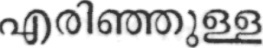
എരിഞ്ഞുള്ള
